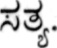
ಸತ್ಯ.
